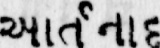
આર્તનાદ
